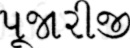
પૂજારીજી!
